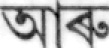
আৰু
